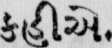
કહીએ.
